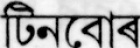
টিনবোৰ
